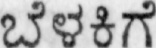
ಬೆಳಕಿಗೆ
